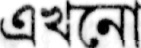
এখনো
